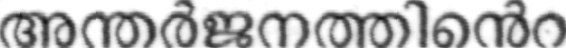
അന്തര്‍ജനത്തിന്റെ
